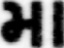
મા
